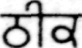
ਠੀਕ
